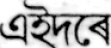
এইদৰে
